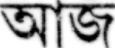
আজ
